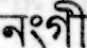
নংগী
